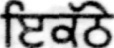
ਇਕੱਠੇ
